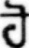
ਹੋ
